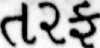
તરફ
